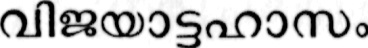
വിജയാട്ടഹാസം
